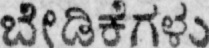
ಬೇಡಿಕೆಗಳು
